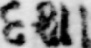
દશા
